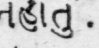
નહોતું.
